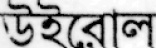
উইরোল
